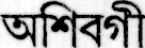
অশিবগী
